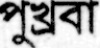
পুখ্রবা
